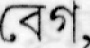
বেগ,
